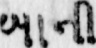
બાની
